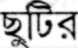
ছুটির
